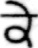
ਕੇ
